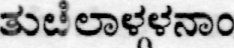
ತುೞೆಲಾಳ್ಗಳನಾ೦
